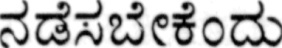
ನಡೆಸಬೇಕೆಂದು
